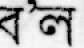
ব'ল
